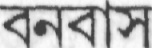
বনবাস
